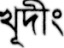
খূদীং
